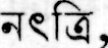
নৎত্রি,
